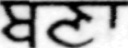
ਬਣਾ
